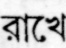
রাখে
